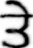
ਤੇ
